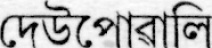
দেউপোৱালি
